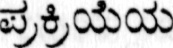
ಪ್ರಕ್ರಿಯೆಯ
